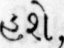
હશે,
